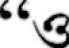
“ও
